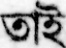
তাই
